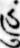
હું
